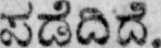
ಪಡೆದಿದೆ.
